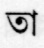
তা
